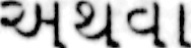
અથવા
